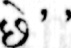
છે"
